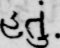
હતું.
